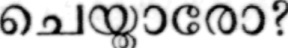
ചെയ്താരോ?
